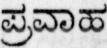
ಪ್ರವಾಹ
